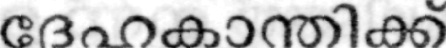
ദേഹകാന്തിക്ക്
